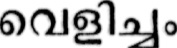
വെളിച്ചം
